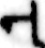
ન
